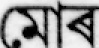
মোৰ
